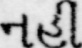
નહીં
